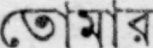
তোমার
